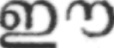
ഈ
